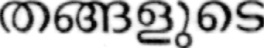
തങ്ങളുടെ
